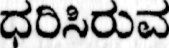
ಧರಿಸಿರುವ
